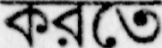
করতে
